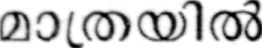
മാത്രയില്‍
